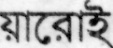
য়ারোই
